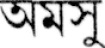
অমসু
